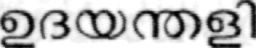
ഉദയന്തളി
